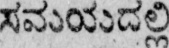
ಸಮಯದಲ್ಲಿ
